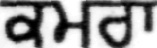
ਕਮਰਾ
